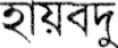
হায়বদু
